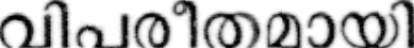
വിപരീതമായി
